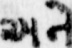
અને
